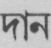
দান
